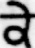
ਕੇ
